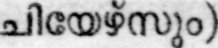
ചിയേഴ്സും)
